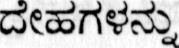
ದೇಹಗಳನ್ನು
